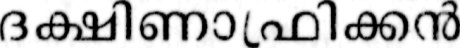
ദക്ഷിണാഫ്രിക്കന്‍
